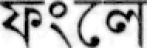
ফংলে
